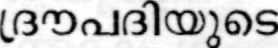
ദ്രൌപദിയുടെ
